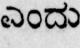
ಎಂದು
